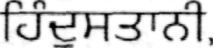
ਹਿੰਦੁਸਤਾਨੀ,
